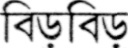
বিড়বিড়
